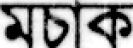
মচাক
